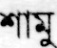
শামু
